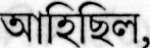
আহিছিল,
